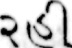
રહી
